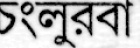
চংলুরবা
